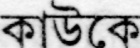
কাউকে
